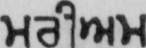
ਮਰੀਅਮ
